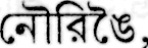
নৌরিঙৈ,
